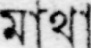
মাথা
